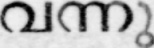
വന്നു
